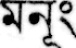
মনূং
